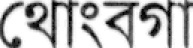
থোংবগা
